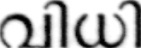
വിധി
